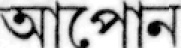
আপোন
